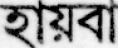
হায়বা
